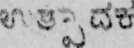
ಉತ್ಪಾದಕ
